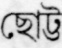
ছোট্ট
